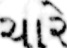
ચારે
